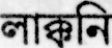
লাক্কনি
